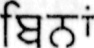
ਬਿਨਾਂ
